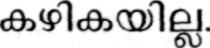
കഴികയില്ല.
